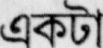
একটা
